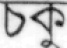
চকু
